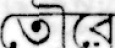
তৌরে
